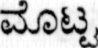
ಮೊಟ್ಟ
